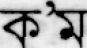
ক'ম
